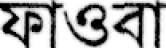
ফাওবা
